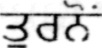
ਤੁਰਨੋਂ
